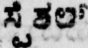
ಸ್ಪೆಶಲ್
